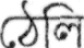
ঠেলি
